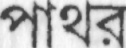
পাথর
